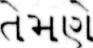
તેમણે
